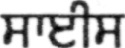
ਸਾਈਸ
